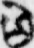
છે
